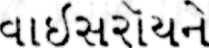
વાઇસરૉયને
